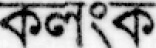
কলংক
